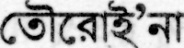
তৌরোই’না
